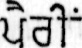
ਪੈਰੀਂ
